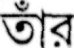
তাঁর
